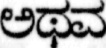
ಅಥವ
